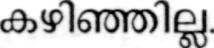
കഴിഞ്ഞില്ല.
